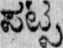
ಪಟ್ಟಿ
